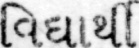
વિધાર્થી
